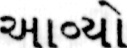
આવ્યો
